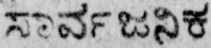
ಸಾರ್ವಜನಿಕ
